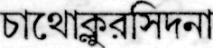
চাথোক্লুরসিদনা
